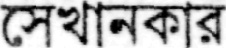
সেখানকার
